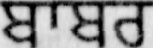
ਬਾਬਰ
